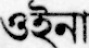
ওইনা
